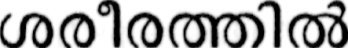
ശരീരത്തില്‍
